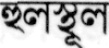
হুলস্থূল
